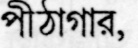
পীঠাগার,
